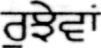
ਰੁਝੇਵਾਂ
